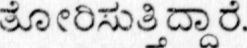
ತೋರಿಸುತ್ತಿದ್ದಾರೆ.
